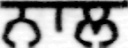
ਨਾਲ
